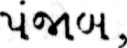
પંજાબ,
